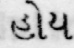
હોય
